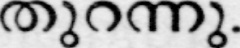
തുറന്നു.
